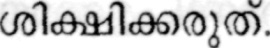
ശിക്ഷിക്കരുത്.
